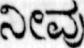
ನೀವು
